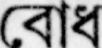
বোধ
